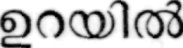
ഉറയില്‍
